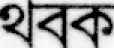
থবক
